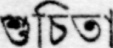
শুচিতা
